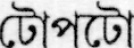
টোপটো
